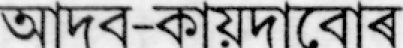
আদব-কায়দাবোৰ
